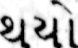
થયો
